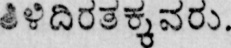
ತಿಳಿದಿರತಕ್ಕವರು.
